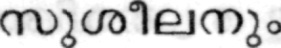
സുശീലനും
